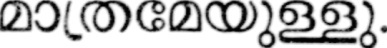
മാത്രമേയുള്ളു.
